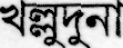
খল্লুদুনা
